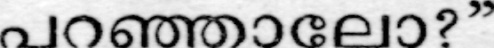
പറഞ്ഞാലോ?"
